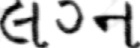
લગ્ન
